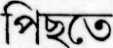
পিছতে
